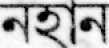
নহান
